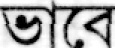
ভাবে
